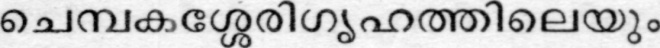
ചെമ്പകശ്ശേരിഗൃഹത്തിലെയും
